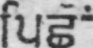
ਪਿਛੋਂ
